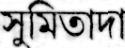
সুমিতাদা
